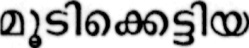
മൂടിക്കെട്ടിയ
